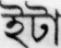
ইটা
